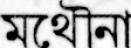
মথৌনা
